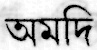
অমদি
